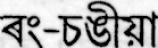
ৰং-চঙীয়া
